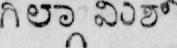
ಗಿಲ್ಗಾಮಿಶ್
